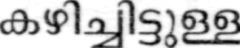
കഴിച്ചിട്ടുള്ള
